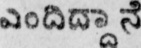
ಎಂದಿದ್ದಾನೆ
